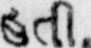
હતી.
